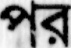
পর
